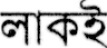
লাকই
